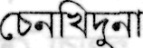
চেনখিদুনা
